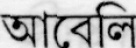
আবেলি
